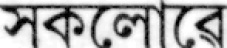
সকলোৱে
